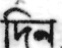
দিন
